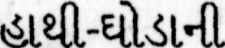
હાથી-ઘોડાની
